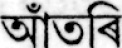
আঁতৰি
